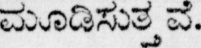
ಮೂಡಿಸುತ್ತವೆ.
